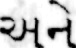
અને
